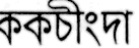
ককচীংদা
